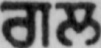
ਗਲ
